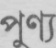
পুণ্য
